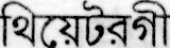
থিয়েটরগী
